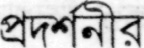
প্রদর্শনীর
